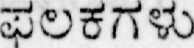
ಫಲಕಗಳು
